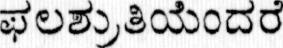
ಫಲಶ್ರುತಿಯೆಂದರೆ
